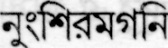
নুংশিরমগনি
